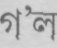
গ'ল
